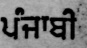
ਪੰਜਾਬੀ
